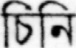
চিনি
